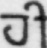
ਹੀ
